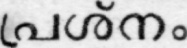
പ്രശ്നം
